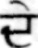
ਦੇ
